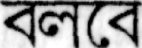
বলবে
